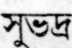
সুভদ্র
